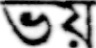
ভয়
